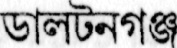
ডালটনগঞ্জ
